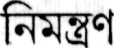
নিমন্ত্রণ
